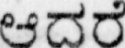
ಆದರೆ
